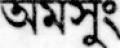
অমসুং
